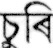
চুৰি
